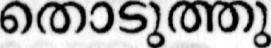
തൊടുത്തു
